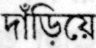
দাঁড়িয়ে
